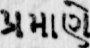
પ્રમાણે
